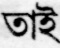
তাই
